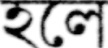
হলে
